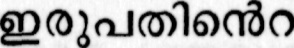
ഇരുപതിന്റെ
